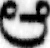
ಆ
